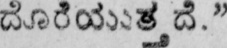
ದೊರೆಯುತ್ತದೆ.”
